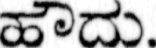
ಹೌದು.
